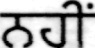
ਨਹੀਂ
